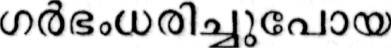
ഗര്‍ഭംധരിച്ചുപോയ
